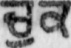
ਚੁਕ
